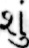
શું
